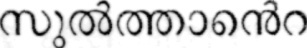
സുല്‍ത്താന്റെ
